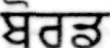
ਬੋਰਡ
